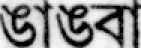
ঙাঙবা
